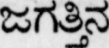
ಜಗತ್ತಿನ
